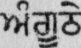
ਅੰਗੂਠੇ
